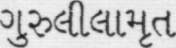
ગુરુલીલામૃત
